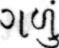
ગળું
